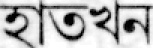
হাতখন
